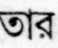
তার
